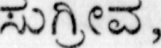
ಸುಗ್ರೀವ,
